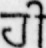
ਹੀ
